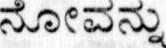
ನೋವನ್ನು
